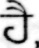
ਹੈ,
